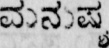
ಮನುಷ್ಯ
